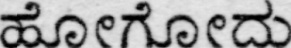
ಹೋಗೋದು
